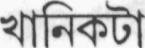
খানিকটা
